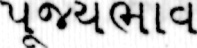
પૂજ્યભાવ
